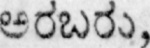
ಅರಬರು,
